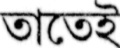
তাতেই
